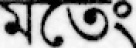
মতেং
